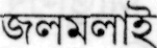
জলমলাই
